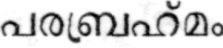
പരബ്രഹ്മം
